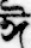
ঈ
